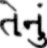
તેનું
